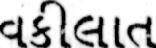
વકીલાત
